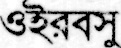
ওইরবসু
